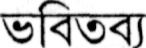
ভবিতব্য
